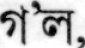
গ'ল,
